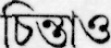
চিন্তাও
